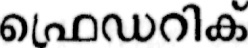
ഫ്രെഡറിക്
